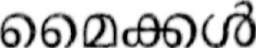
മൈക്കള്‍
